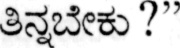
ತಿನ್ನಬೇಕು?’’
